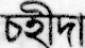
চহীদা
